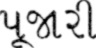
પૂજારી
